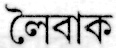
লৈবাক
